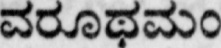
ವರೂಥಮಂ
